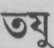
তযু
